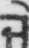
ਜੇ
